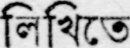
লিখিতে
